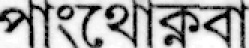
পাংথোক্নবা
